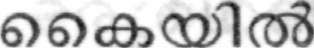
കൈയില്‍
